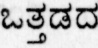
ಒತ್ತಡದ
